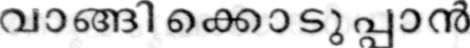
വാങ്ങിക്കൊടുപ്പാന്‍
